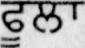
ਫੂਲਾ
